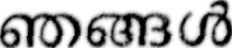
ഞങ്ങള്‍
